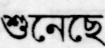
শুনেছে
